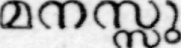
മനസ്സു
